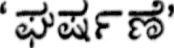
'ಘರ್ಷಣೆ'
